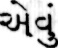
એવું
